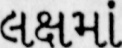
લક્ષમાં
